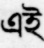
এই
